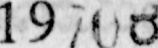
1970ರ
